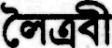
লৈত্রবী
